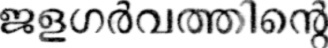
ജളഗര്‍വത്തിന്റെ
